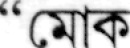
"মোক
